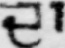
ਦਾ
